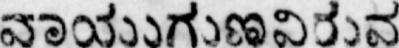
ವಾಯುಗುಣವಿರುವ
